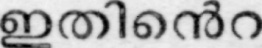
ഇതിന്റെ
